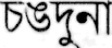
চঙদুনা
